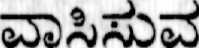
ವಾಸಿಸುವ
